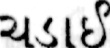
ચડાઈ
